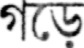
গড়ে
